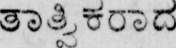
ತಾತ್ವಿಕರಾದ
